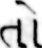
તો
